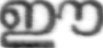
ഈ
